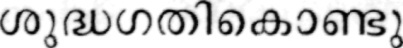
ശുദ്ധഗതികൊണ്ടു
